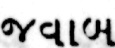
જવાબ
